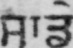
ਸਾਡੇ
